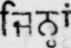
ਜਿਨ੍ਹਾਂ
